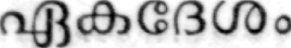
ഏകദേശം
